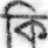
কি
